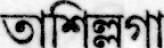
তাশিল্লগা
